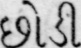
છોડી
